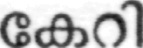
കേറി
